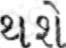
થશે
